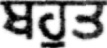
ਬਹੁਤ
